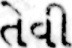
તેવી
